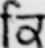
ਕਿ
